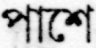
পাশে
